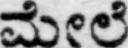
ಮೇಲೆ
